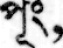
পূং,
